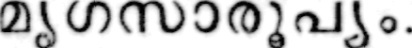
മൃഗസാരൂപ്യം.
